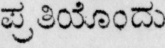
ಪ್ರತಿಯೊಂದು
